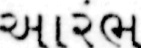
આરંભ
